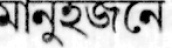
মানুহজনে
